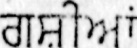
ਗਸ਼ੀਆਂ
